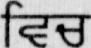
ਵਿਚ
